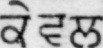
ਕੇਵਲ
